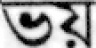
ভয়
